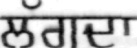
ਲੱਗਦਾ
